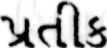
પ્રતીક
